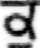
ਕੁ
